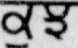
ਕੁਝ
